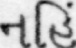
નહિં
